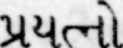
પ્રયત્નો
